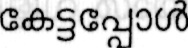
കേട്ടപ്പോള്‍
